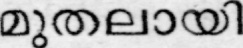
മുതലായി
